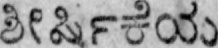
ಶೀರ್ಷಿಕೆಯ
